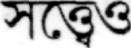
সত্ত্বেও
